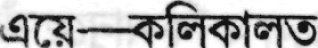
এয়ে-কলিকালত
